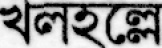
খলহল্লে
